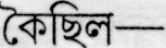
কৈছিল-
